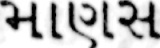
માણસ
